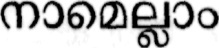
നാമെല്ലാം
